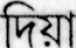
দিয়া
